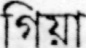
গিয়া
